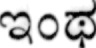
ಇಂಥ
